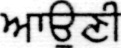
ਆਉਣੀ
